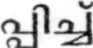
പ്പിച്ച്
